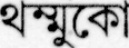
থম্মুকো
